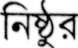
নিষ্ঠুর
